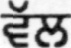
ਵੱਲ
